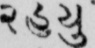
રહ્યું
